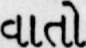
વાતો
